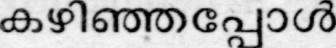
കഴിഞ്ഞപ്പോള്‍
